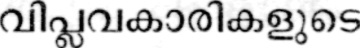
വിപ്ലവകാരികളുടെ
